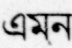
এমন
